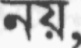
নয়,
